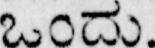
ಒಂದು.
